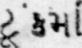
ટૂંકમાં
